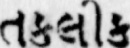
તકલીક
